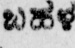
ಬಹಳ
